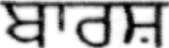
ਬਾਰਸ਼
